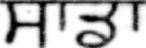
ਸਾਡਾ
